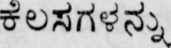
ಕೆಲಸಗಳನ್ನು
